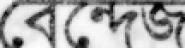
বেন্দেজ
